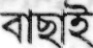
বাছাই
